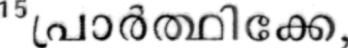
15പ്രാര്‍ത്ഥിക്കേ,
